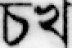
চখ
